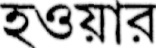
হওয়ার
